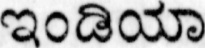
ಇಂಡಿಯಾ
